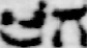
ಆಗ
